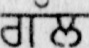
ਗੱਲ
